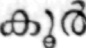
കൂര്‍
